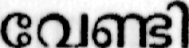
വേണ്ടി
